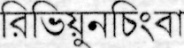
রিভিয়ুনচিংবা
